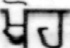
ਖੋਹ
